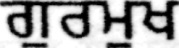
ਗੁਰਮੁਖ
